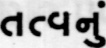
તત્વનું
